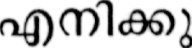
എനിക്കു
